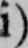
i)
